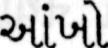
આંખો
